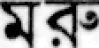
মরু
